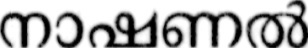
നാഷണല്‍
